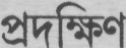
প্ৰদক্ষিণ
